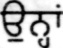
ਉਨ੍ਹਾਂ
